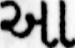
આ
